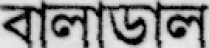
বালাডাল
